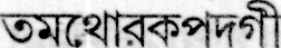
তমথোরকপদগী
